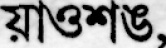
য়াওশঙ,
